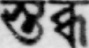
স্তব্ধ
